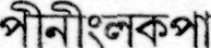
পীনীংলকপা
